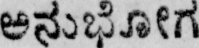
ಅನುಭೋಗ
